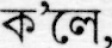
ক'লে,
